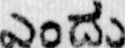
ಎಂದು
